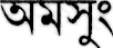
অমসুং
